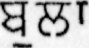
ਬੁਲਾ
